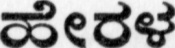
ಹೇರಳ
